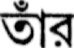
তাঁর
